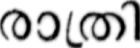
രാത്രി
